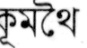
কূমথৈ
